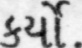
કર્યો.
